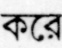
করে
